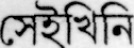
সেইখিনি
